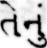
તેનું
